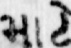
માટે
